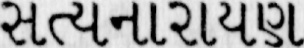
સત્યનારાયણ
